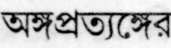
অঙ্গপ্রত্যঙ্গের
